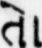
તો
